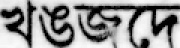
খঙজদে
